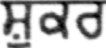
ਸ਼ੁਕਰ
